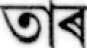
তাৰ
